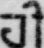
ਹੀ
